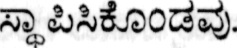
ಸ್ಥಾಪಿಸಿಕೊಂಡವು.
